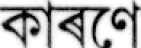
কাৰণে
